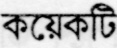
কয়েকটি
